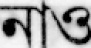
নাও
